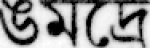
ঙমদ্রে
